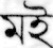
মই
